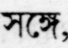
সঙ্গে,
